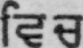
ਵਿਚ
